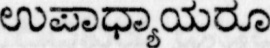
ಉಪಾಧ್ಯಾಯರೂ
